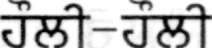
ਹੌਲੀ-ਹੌਲੀ
